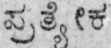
ಪ್ರತ್ಯೇಕ
